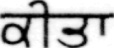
ਕੀਤਾ
